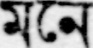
মনে
